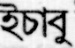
ইচাবু
